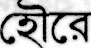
হৌরে
